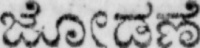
ಜೋಡಣೆ
